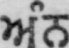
ਅੰਨ
